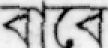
বাবে
